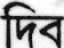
দিব
